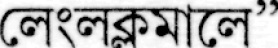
লেংলক্লমাল্লে”
